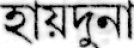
হায়দুনা
